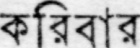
করিবার
